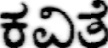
ಕವಿತೆ
